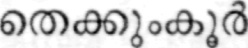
തെക്കുംകൂര്‍
